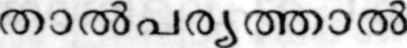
താല്‍പര്യത്താല്‍
